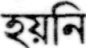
হয়নি
